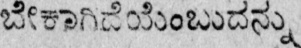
ಬೇಕಾಗಿದೆಯೆಂಬುದನ್ನು
